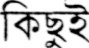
কিছুই
